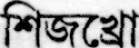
শিজখ্রো
